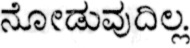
ನೋಡುವುದಿಲ್ಲ.
